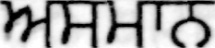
ਅਸਮਾਨ
